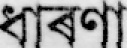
ধাৰণা
